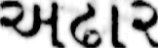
અઢાર
